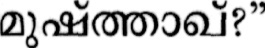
മുഷ്ത്താഖ്?”
